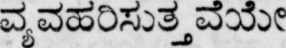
ವ್ಯವಹರಿಸುತ್ತವೆಯೇ
